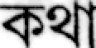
কথা
